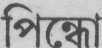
পিন্ধো
